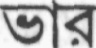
ভার
